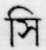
সি
